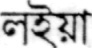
লইয়া
